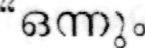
“ഒന്നും
